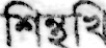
শিন্থখি
